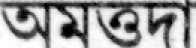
অমত্তদা
